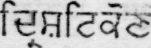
ਦ੍ਰਿਸ਼ਟਿਕੋਣ
